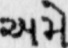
અમે
